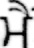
ਮੈਂ
